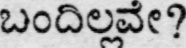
ಬಂದಿಲ್ಲವೇ?
